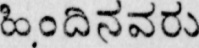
ಹಿಂದಿನವರು
